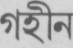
গহীন
